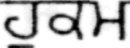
ਹੁਕਮ
